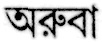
অরুবা
